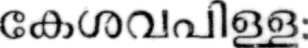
കേശവപിള്ള:
